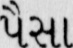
પૈસા
